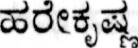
ಹರೇಕೃಷ್ಣ
